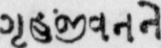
ગૃહજીવનને
